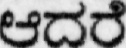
ಆದರೆ
